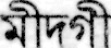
মীদগী
